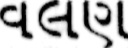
વલણ
